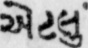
એટલું
